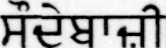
ਸੌਦੇਬਾਜ਼ੀ
